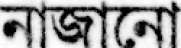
নাজানো
